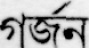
গর্জন
